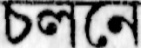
চলনে
